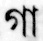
গা
